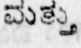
ಮತ್ತು
